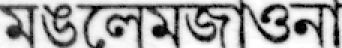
মঙলেমজাওনা
